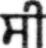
ਸੀ
